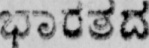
ಭಾರತದ
